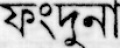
ফংদুনা
